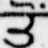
ਤੋਂ
